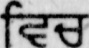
ਵਿਚ
